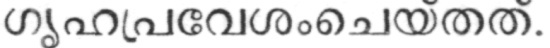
ഗൃഹപ്രവേശംചെയ്തത്.
